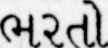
ભરતો
